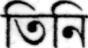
তিনি
